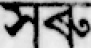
সৰু
